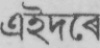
এইদৰে
